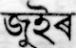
জুইৰ
